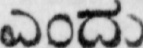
ಎಂದು
